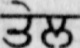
ਤੇਲ
